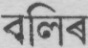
বলিৰ
